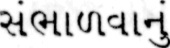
સંભાળવાનું
